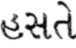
હસતે
